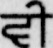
ਵੀ
